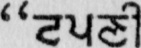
''ਟਪਣੀ
